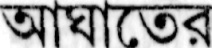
আঘাতের
